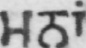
ਮਨਾਂ
